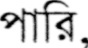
পারি,
